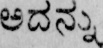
ಅದನ್ನು
